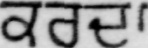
ਕਰਦਾ
